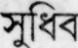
সুধিব
